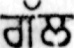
ਗੱਲ
